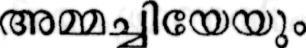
അമ്മച്ചിയേയും
